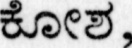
ಕೋಶ,
